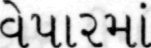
વેપારમાં
